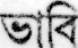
ভাবি
